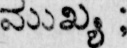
ಮುಖ್ಯ;
